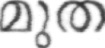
മുത
